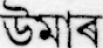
উমাৰ
